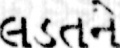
લડતને
